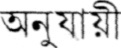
অনুযায়ী
